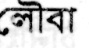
লৌবা
